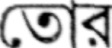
তোর
